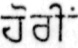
ਹੋਰੀਂ
